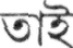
তাই
